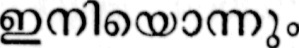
ഇനിയൊന്നും
